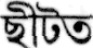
ছীটত
